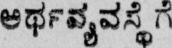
ಅರ್ಥವ್ಯವಸ್ಥೆಗೆ
